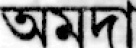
অমদা
